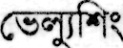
ভেল্যুশিং
